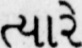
ત્યારે
